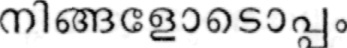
നിങ്ങളോടൊപ്പം
